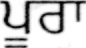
ਪੂਰਾ
